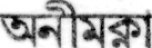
অনীমক্না
